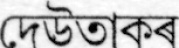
দেউতাকৰ
